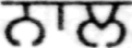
ਨਾਲ
